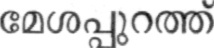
മേശപ്പുറത്ത്
